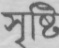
সৃষ্টি
